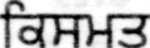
ਕਿਸਮਤ
